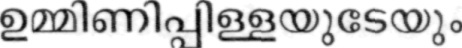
ഉമ്മിണിപ്പിള്ളയുടേയും
